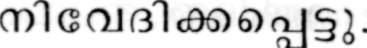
നിവേദിക്കപ്പെട്ടു.
